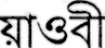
য়াওবী
